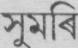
সুমৰি
